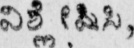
ವಿಶ್ಲೇಷಿಸಿ,
